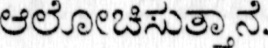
ಆಲೋಚಿಸುತ್ತಾನೆ.
